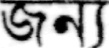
জন্য
